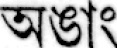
অঙাং
